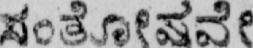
ಸಂತೋಷವೇ
